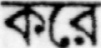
করে
